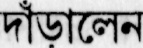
দাঁড়ালেন
